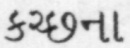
કચ્છના
